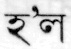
হ'ল
